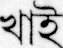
খাই
